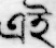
এই
